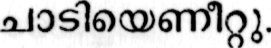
ചാടിയെണീറ്റു.
